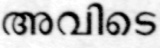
അവിടെ
